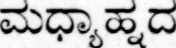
ಮಧ್ಯಾಹ್ನದ
